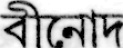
বীনোদ
